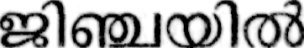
ജിഞ്ചയില്‍
